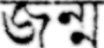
জন্ম
